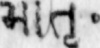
માતૃ
